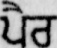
ਪੈਰ
